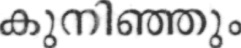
കുനിഞ്ഞും
